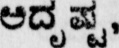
ಅದೃಷ್ಟ,
